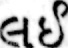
લઈ
